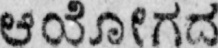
ಆಯೋಗದ
